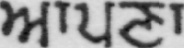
ਆਪਣਾ
